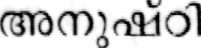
അനുഷ്ഠി
